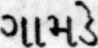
ગામડે
